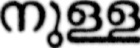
നുള്ള
